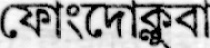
ফোংদোক্লুবা
